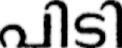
പിടി
